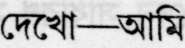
দেখো–আমি
